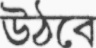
উঠবে
